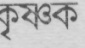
কৃষ্ণক
